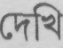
দেখি
